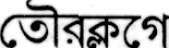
তৌরক্লগে
